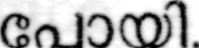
പോയി.
